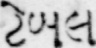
ટેબલ
